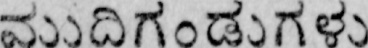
ಮುದಿಗಂಡುಗಳು
